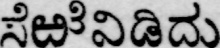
ಸೆಱೆವಿಡಿದು
